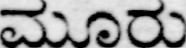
ಮೂರು
